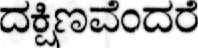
ದಕ್ಷಿಣವೆಂದರೆ
